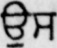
ਉਸ
